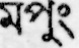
মপুং
